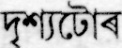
দৃশ্যটোৰ
